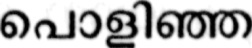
പൊളിഞ്ഞ
